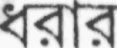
ধরার
